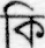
কি
